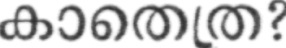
കാതെത്ര?
